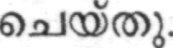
ചെയ്തു.
